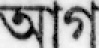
আগ
